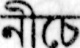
নীচে
